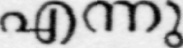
എന്നു
